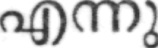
എന്നു
